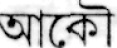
আকৌ
